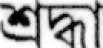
শ্রদ্ধা
